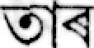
তাৰ
